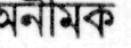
অনীমক
